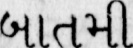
બાતમી
